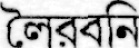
লৈরবনি
